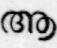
ആ
